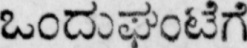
ಒಂದುಘಂಟೆಗೆ
